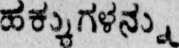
ಹಕ್ಕುಗಳನ್ನು
